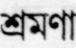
শ্রমণা
